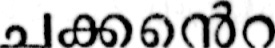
ചക്കന്റെ
